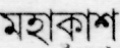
মহাকাশ
